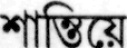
শান্তিয়ে
